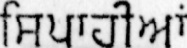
ਸਿਪਾਹੀਆਂ
